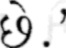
છે.'
